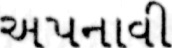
અપનાવી
